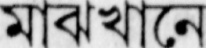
মাঝখানে
